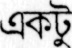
একটু
